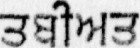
ਤਬੀਅਤ
